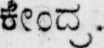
ಕೇಂದ್ರ.
